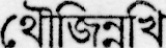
থৌজিন্নখি
